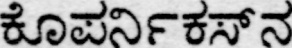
ಕೊಪರ್ನಿಕಸ್ನ
